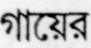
গায়ের
